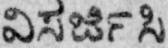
ವಿಸರ್ಜಿಸಿ
